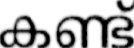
കണ്ട്
